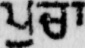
ਪੁਚਾ
